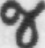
જ
